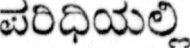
ಪರಿಧಿಯಲ್ಲಿ
